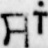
ਸਾਂ
